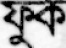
ফুক
